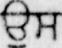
ਉਸ
